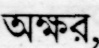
অক্ষর,
